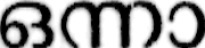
ഒന്നാ
